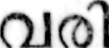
വരി
